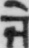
ਜੇ
